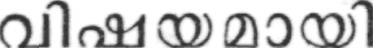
വിഷയമായി
